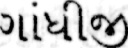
ગાંધીજી
